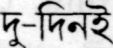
দু-দিনই
